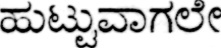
ಹುಟ್ಟುವಾಗಲೇ
